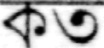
কত
